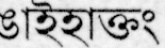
ঙাইহাক্তং
